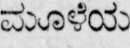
ಮೂಳೆಯ
